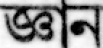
জ্ঞান
